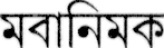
মবানিমক
